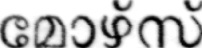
മോഴ്സ്
